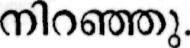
നിറഞ്ഞു.
